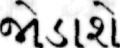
જોડાશે
